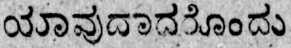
ಯಾವುದಾದರೊಂದು
